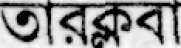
তারক্লবা
